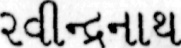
રવીન્દ્રનાથ
